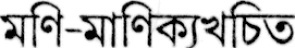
মণি-মাণিক্যখচিত
